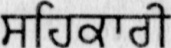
ਸਹਿਕਾਰੀ
